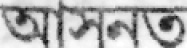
আসনত
